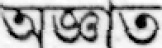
অজ্ঞাত
